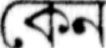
কেন
